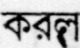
করল
